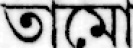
তামো
